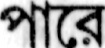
পারে
